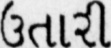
ઉતારી
